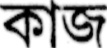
কাজ
